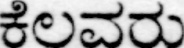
ಕೆಲವರು
